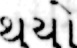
થયો
